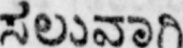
ಸಲುವಾಗಿ
